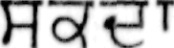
ਸਕਦਾ
